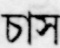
চাস
